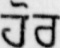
ਹੋਰ
